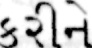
કરીને
